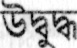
উদ্বুদ্ধ
